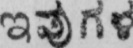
ಇವುಗಳ
